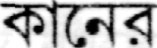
কানের
